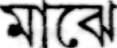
মাঝে
